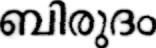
ബിരുദം
